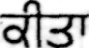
ਕੀਤਾ
